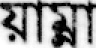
য়াম্না
